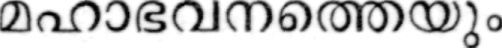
മഹാഭവനത്തെയും
